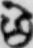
છે
